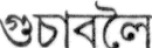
গুচাবলৈ
